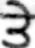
ਤੇ
